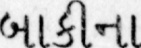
બાકીના
